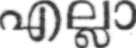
എല്ലാ
